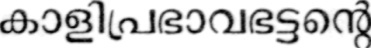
കാളിപ്രഭാവഭട്ടന്റെ
